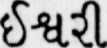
ઇશ્વરી
